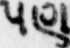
પણ
